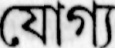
যোগ্য
